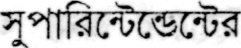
সুপারিন্টেন্ডেন্টের
